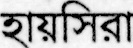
হায়সিরা
